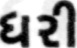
ધરી
